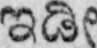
ಇಡೀ
